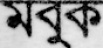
মবুক
